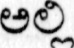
ಅಲ್ಲಿ
